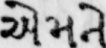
એમને
